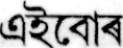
এইবোৰ
